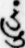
હું
